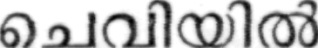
ചെവിയില്‍
